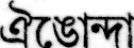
ঐঙোন্দা
